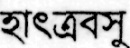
হাৎত্রবসু
